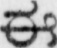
ಈ
